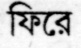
ফিরে
